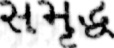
સમૃદ્ધ
